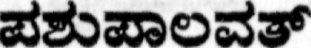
ಪಶುಪಾಲವತ್
